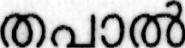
തപാല്‍
